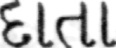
દાતા
